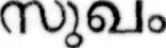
സുഖം
